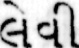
લેવી
